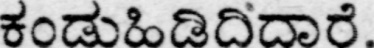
ಕ೦ಡುಹಿಡಿದಿದಾರೆ,
